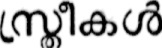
സ്ത്രീകള്‍
